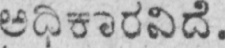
ಅಧಿಕಾರವಿದೆ.
